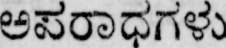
ಅಪರಾಧಗಳು
